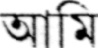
আমি
